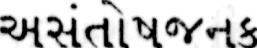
અસંતોષજનક
